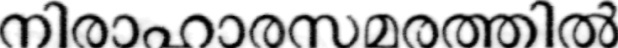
നിരാഹാരസമരത്തില്‍
